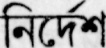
নির্দেশ
